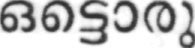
ഒട്ടൊരു
